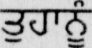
ਤੁਹਾਨੂੰ
